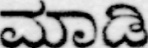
ಮಾಡಿ
